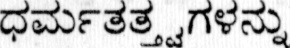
ಧರ್ಮತತ್ತ್ವಗಳನ್ನು
